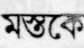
মস্তকে
